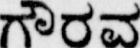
ಗೌರವ
